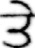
ਤੇ
